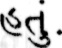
હતું.
